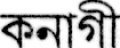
কনাগী
